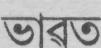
ভাৱত
